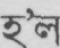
হ'ল
